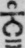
ਨੂੰ
